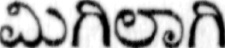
ಮಿಗಿಲಾಗಿ
